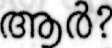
ആര്‍?
